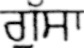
ਗੁੱਸਾ
